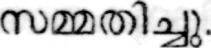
സമ്മതിച്ചു.
